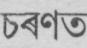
চৰণত
